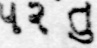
પરંતુ
